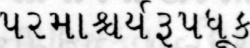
પરમાશ્ર્ચર્યરૂપધૂક
